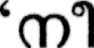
'നീ
